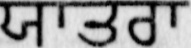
ਯਾਤਰਾ
